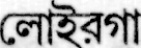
লোইরগা
